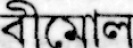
বীমোল
